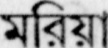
মরিয়া
